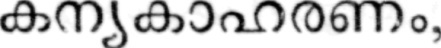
കന്യകാഹരണം,
